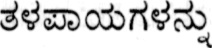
ತಳಪಾಯಗಳನ್ನು
